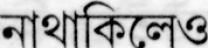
নাথাকিলেও
